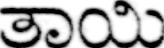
ತಾಯಿ
